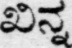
ಖಿನ್ನ
